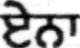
ਏਨਾ
